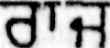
ਰਾਜ
